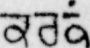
ਕਰਕੇ
